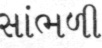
સાંભળી
